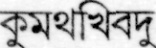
কুমথখিবদু
